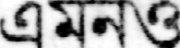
এমনও
